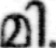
മി.
